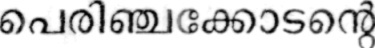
പെരിഞ്ചക്കോടന്റെ
